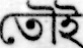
তৌই
